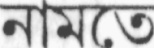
নামতে
